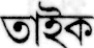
তাইক
